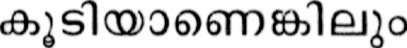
കൂടിയാണെങ്കിലും
